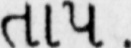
તાપ.
